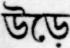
উড়ে
